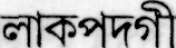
লাকপদগী
